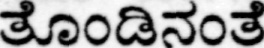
ತೊಂಡಿನಂತೆ
